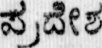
ಪ್ರದೇಶ
